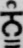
ਨੂੰ
